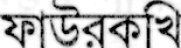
ফাউরকখি
